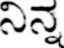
ನಿನ್ನ
